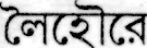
লৈহৌরে
